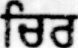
ਚਿਰ
